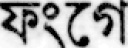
ফংগে
